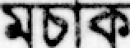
মচাক
